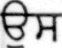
ਉਸ
